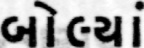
બોલ્યાં
